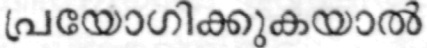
പ്രയോഗിക്കുകയാല്‍
